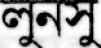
লুনসু
